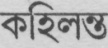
কহিলন্ত
